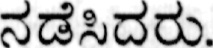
ನಡೆಸಿದರು.
